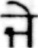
ਜੇ
